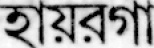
হায়রগা
